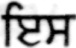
ਇਸ
